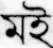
মই
